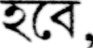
হবে,
